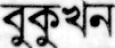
বুকুখন
